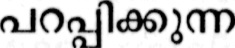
പറപ്പിക്കുന്ന
